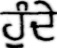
ਹੁੰਦੇ
